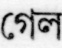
গেল
